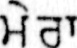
ਮੇਰਾ
